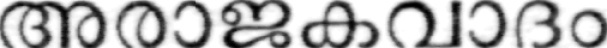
അരാജകവാദം
